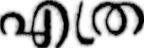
എത്ര
